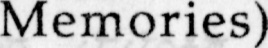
Memories)
